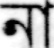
না
